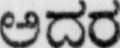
ಅದರ
